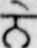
ਨੇ
